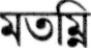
মতম্নি
